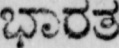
ಭಾರತ
